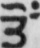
ਤੋਂ
